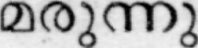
മരുന്നു
